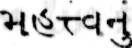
મહત્ત્વનું
